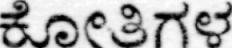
ಕೋತಿಗಳ
